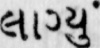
લાગ્યું
